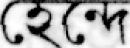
হেন্দে
